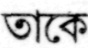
তাকে
